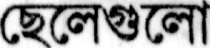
ছেলেগুলো
